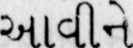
આવીને
